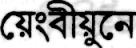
য়েংবীয়ুনা
